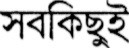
সবকিছুই
